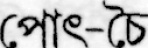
পোৎ-চৈ
